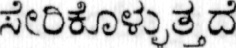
ಸೇರಿಕೊಳ್ಳುತ್ತದೆ
